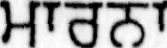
ਮਾਰਨਾ
